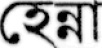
হেন্না
